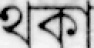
থকা
